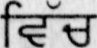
ਵਿੱਚ
